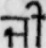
ਜੀ
